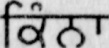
ਕਿੰਨਾ
